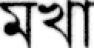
মখা
